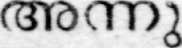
അന്നു
